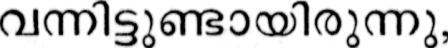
വന്നിട്ടുണ്ടായിരുന്നു,
